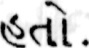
હતો.
